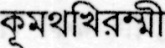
কূমথখিরম্মী
